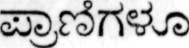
ಪ್ರಾಣಿಗಳೂ
